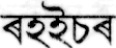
ৰহইচৰ
